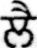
ਲੈ
